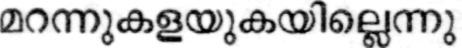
മറന്നുകളയുകയില്ലെന്നു
